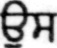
ਉਸ
